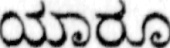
ಯಾರೂ
